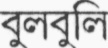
বুলবুলি
